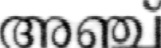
അഞ്ച്
